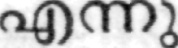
എന്നു
